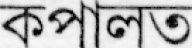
কপালত
